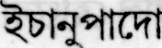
ইচানুপাদো
